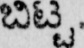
ಬಿಟ್ಟ.
